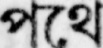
পথে
